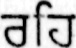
ਰਹਿ
